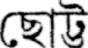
ছোট্ট
